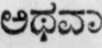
ಅಥವಾ
